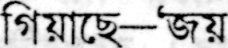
গিয়াছে—‘জয়
